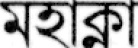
মহাক্না
